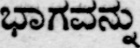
ಭಾಗವನ್ನು
